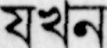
যখন
